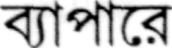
ব্যাপারে
